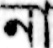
না
